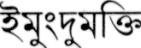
ইমুংদুমক্তি
